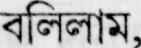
বলিলাম,
